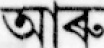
আৰু
